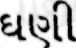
ઘણી
